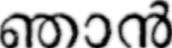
ഞാന്‍
